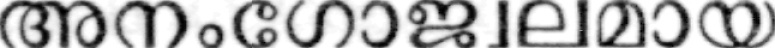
അനംഗോജ്വലമായ
